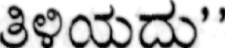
ತಿಳಿಯದು"
